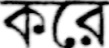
করে
